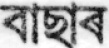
বাছাৰ
